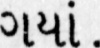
ગયાં.
